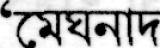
‘মেঘনাদ
